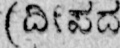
(ದೀಪದ
